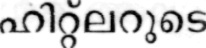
ഹിറ്റ്ലറുടെ
